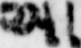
આ
